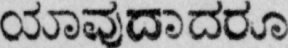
ಯಾವುದಾದರೂ
